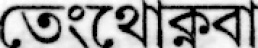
তেংথোক্লগা
